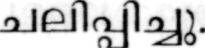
ചലിപ്പിച്ചു.
